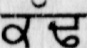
ਕੱਢ
